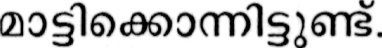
മാട്ടിക്കൊന്നിട്ടുണ്ട്.
